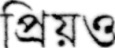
প্রিয়ও
